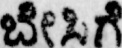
ಬೇಸಿಗೆ
